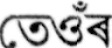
তেওঁৰ
